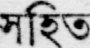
সহিত
